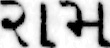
રામ
